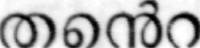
തന്റെ
